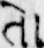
તો
